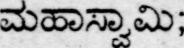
ಮಹಾಸ್ವಾಮಿ;
